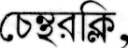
চেন্থরক্লি,
